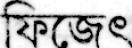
ফিজেৎ
